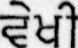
ਵੇਖੀ
